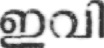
ഇവി
